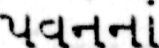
પવનનાં
